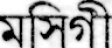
মসিগী
